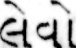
લેવો
